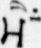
ਮੈਂ
